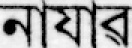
নাযাৱ
